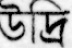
উদ্রি
